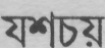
যশচয়
